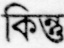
কিন্তু
